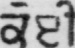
ਕੋਈ
